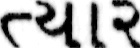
ત્યાર
